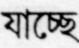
যাচ্ছে
